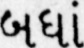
બધાં
